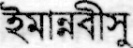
ইমান্নবীসু
